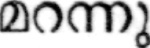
മറന്നു
